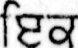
ਇਕ
